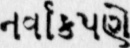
નર્વાકપણે
